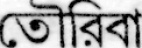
তৌরিবা
